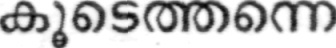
കൂടെത്തന്നെ
